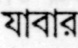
যাবার
